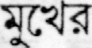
মুখের
